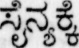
ಸೈನ್ಯಕ್ಕೆ
